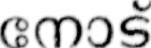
നോട്
